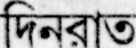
দিনরাত
